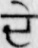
ਦੇ
